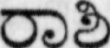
ರಾಶಿ
